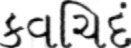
કવચિદં
